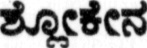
ಶ್ಲೋಕೇನ
